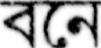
বনে
